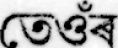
তেওঁৰ
